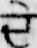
ਦੇ
